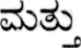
ಮತ್ತು
